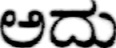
ಅದು
